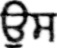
ਉਸ
